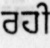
ਰਹੀ
